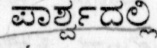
ಪಾರ್ಶ್ವದಲ್ಲಿ
